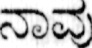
ನಾವು
